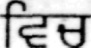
ਵਿਚ
